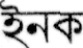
ইনক
